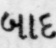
બાદ
